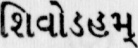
શિવોડહમ્
